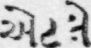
એટલે
